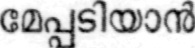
മേപ്പടിയാന്‍
